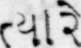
ત્યારે
